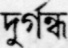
দুর্গন্ধ
